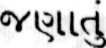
જણાતું
